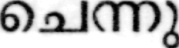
ചെന്നു
